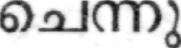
ചെന്നു
